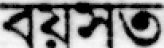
বয়সত
